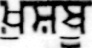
ਖ਼ੁਸ਼ਬੂ
